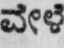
ವೇಳೆ
